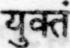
युक्तं
